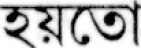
হয়তো
